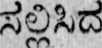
ಸಲ್ಲಿಸಿದ
